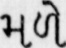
મળે
